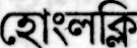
হোংলক্লি
